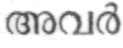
അവര്‍
